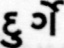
દુર્ગે
